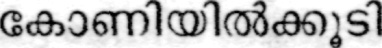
കോണിയില്‍ക്കൂടി
